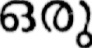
ഒരു
